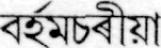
বর্হমচৰীয়া
